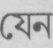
যেন
